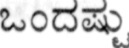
ಒಂದಷ್ಟು
